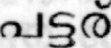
പട്ടര്
